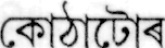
কোঠাটোৰ
